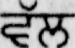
ਵੱਲ
